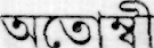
অতোম্বী
